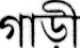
গাড়ী
